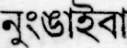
নুংঙাইবা
